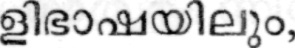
ളിഭാഷയിലും,
